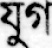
যুগ
